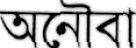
অনৌবা
